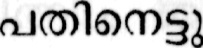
പതിനെട്ടു
